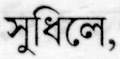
সুধিলে,
